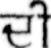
ਦੀ
